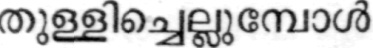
തുള്ളിച്ചെല്ലുമ്പോള്‍
